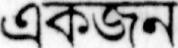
একজন
